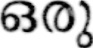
ഒരു
